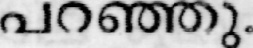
പറഞ്ഞു.
